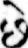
છે
